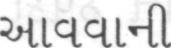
આવવાની
